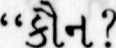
"કૌન?
